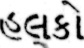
હલકો
